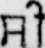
ਸੀ
